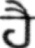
ਹੈ
